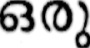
ഒരു
